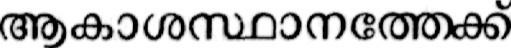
ആകാശസ്ഥാനത്തേക്ക്
